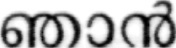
ഞാന്‍
